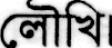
লৌখি।
